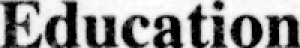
Education
